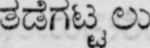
ತಡೆಗಟ್ಟಲು
